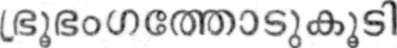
ഭ്രൂഭംഗത്തോടുകൂടി
